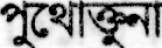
পুথোক্তুনা
